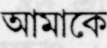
আমাকে
